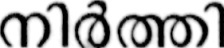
നിര്‍ത്തി
